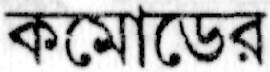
কমোডের
